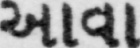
આવા
